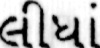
લીધાં
